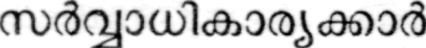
സര്‍വ്വാധികാര്യക്കാര്‍
